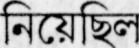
নিয়েছিল
